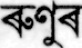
ৰুণুৰ
